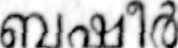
ബഷീര്‍
